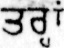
ਤਰ੍ਹਾਂ
